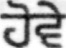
ਹੋਵੇ
